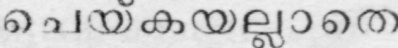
ചെയ്കയല്ലാതെ
